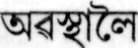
অৱস্হালৈ
